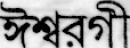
ঈশ্বরগী
